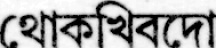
থোকখিবদো
